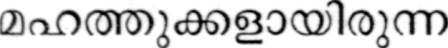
മഹത്തുക്കളായിരുന്ന
